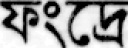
ফংদ্রে
